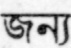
জন্য
